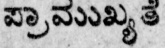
ಪ್ರಾಮುಖ್ಯತೆ
